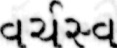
વર્ચસ્વ
